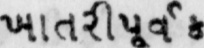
ખાતરીપૂર્વક
